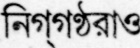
নিগ্গণ্ঠরাও
